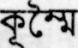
কূম্মৈ
